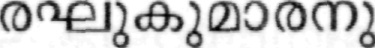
രഘുകുമാരനു
